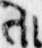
તો
